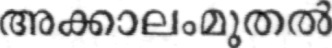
അക്കാലംമുതല്‍
